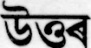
উত্তৰ
